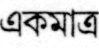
একমাত্র
